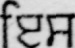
ਇਸ
